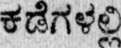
ಕಡೆಗಲಲ್ಲಿ
